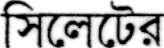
সিলেটের
